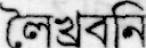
লৈখ্রবনি
